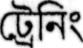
ট্রেনিং
